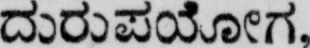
ದುರುಪಯೋಗ,
